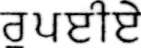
ਰੁਪਈਏ
